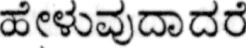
ಹೇಳುವುದಾದರೆ
